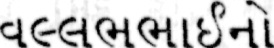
વલ્લભભાઈનો
